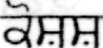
ਕੋਸ਼ਸ਼
